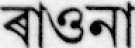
ৰাওনা
